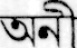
অনী
